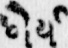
ધૈર્ય
